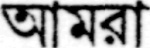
আমরা
